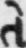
તે
